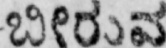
ಬೀರುವ
